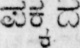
ಪಕ್ಕದ
